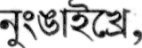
নুংঙাইখ্রে,
